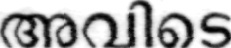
അവിടെ
